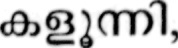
കളൂന്നി,
